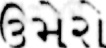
ઉમેરો
